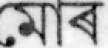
মোৰ
